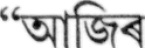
"আজিৰ
